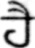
ਹੈ
